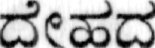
ದೇಹದ
